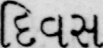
દિવસ
